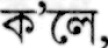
ক'লে,
